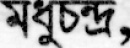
মধুচন্দ্র,
